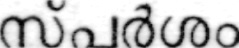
സ്പര്‍ശം
